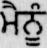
ਮੈਨੂੰ
